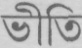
ভীতি
